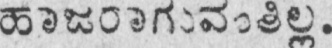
ಹಾಜರಾಗುವಂತಿಲ್ಲ.
